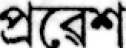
প্ৰৱেশ
